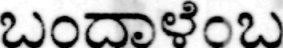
ಬಂದಾಳೆಂಬ
